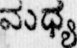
ಮಧ್ಯ
